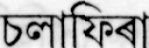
চলাফিৰা
